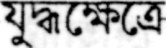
যুদ্ধক্ষেত্রে
